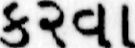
કરવા
